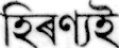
হিৰণ্যই
